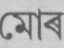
মোৰ
